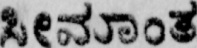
ಸೀಮಾಂತ
